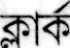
ক্লার্ক
